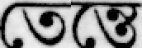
তেন্তে
